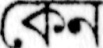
কেন
